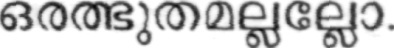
ഒരത്ഭുതമല്ലല്ലോ.
